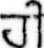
ਹੀ
